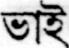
ভাই
